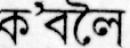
ক'বলৈ
